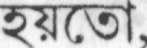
হয়তো,
